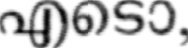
എടൊ,
